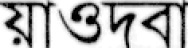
য়াওদবা
